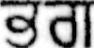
ਭਗ
